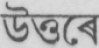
উত্তৰে
